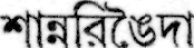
শান্নরিঙৈদা
